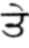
ਤੇ
